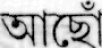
আছোঁ
